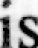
is
